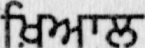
ਖ਼ਿਆਲ
